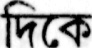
দিকে
